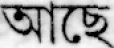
আছে
